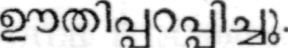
ഊതിപ്പറപ്പിച്ചു.
